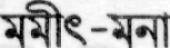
মমীৎ-মনা
